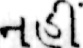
નહીં
